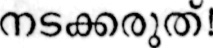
നടക്കരുത്!
